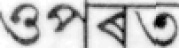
ওপৰত
